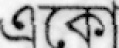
একো
